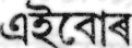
এইবোৰ
